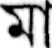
মা
